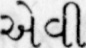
એવી
